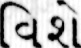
વિશે
